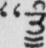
''ਤੂੰ
